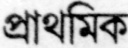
প্রাথমিক
